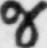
જ
